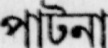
পাটনা
